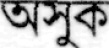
অসুক
